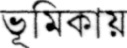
ভূমিকায়
